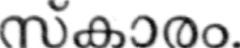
സ്കാരം.
